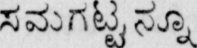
ಸಮಗಟ್ಟನ್ನೂ
